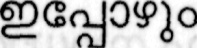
ഇപ്പോഴും
